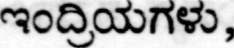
ಇಂದ್ರಿಯಗಳು,
